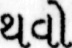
થવો
